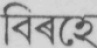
বিৰহে
